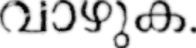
വാഴുക.
